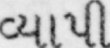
વ્યાપી
